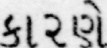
કારણે
